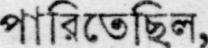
পারিতেছিল,
